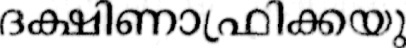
ദക്ഷിണാഫ്രിക്കയു
